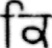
ਕਿ
